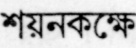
শয়নকক্ষে
